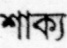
শাক্য
